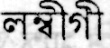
লম্বীগী
